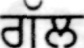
ਗੱਲ
